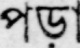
পড়া
